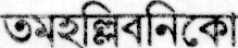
তমহল্লিবনিকো
